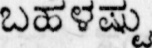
ಬಹಳಷ್ಟು
